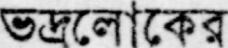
ভদ্রলোকের
